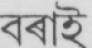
বৰাই
